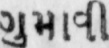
ગુમાવી
